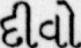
દીવો
